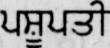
ਪਸ਼ੂਪਤੀ
